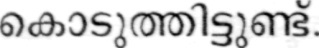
കൊടുത്തിട്ടുണ്ട്.
